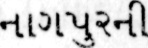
નાગપુરની
